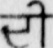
ਦੀ
